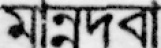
মান্নদবা
